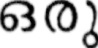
ഒരു
